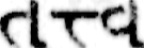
તત્ત્વ
